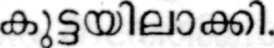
കുട്ടയിലാക്കി.
